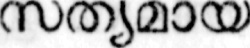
സത്യമായ
